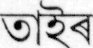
তাইৰ
